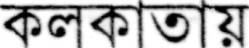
কলকাতায়
